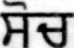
ਸੋਚ
